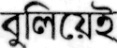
বুলিয়েই
